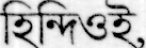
হিন্দিওই,
